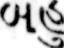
બહુ
